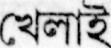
খেলাই
